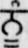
ਨੂੰ
